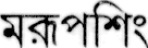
মরূপশিং
